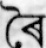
ৰৈ
